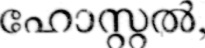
ഹോസ്റ്റല്‍,
